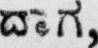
ದಾಗ,
